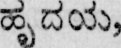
ಹೃದಯ,
